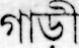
গাড়ী
